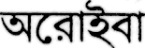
অরোইবা
